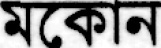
মকোন
